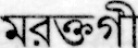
মরক্তগী
